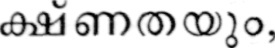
ക്ഷ്ണതയും,
